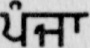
ਪੰਜਾ
